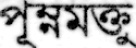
পুম্নমক্তু
